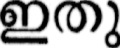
ഇതു
